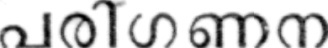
പരിഗണന
